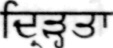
ਦ੍ਰਿੜ੍ਹਤਾ
